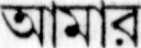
আমার
